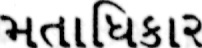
મતાધિકાર
